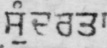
ਸੁੰਦਰਤਾ
